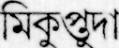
মিকুপ্তুদা
